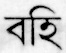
বহি
